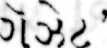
ગેઝેટ'
